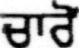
ਚਾਰੋਂ
